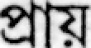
প্রায়
